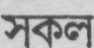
সকল
